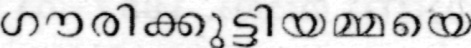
ഗൌരിക്കുട്ടിയമ്മയെ
